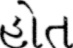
હોત
